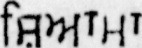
ਸ਼ਿਆਮਾ
